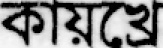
কায়খ্রে
